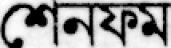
শেনফম
